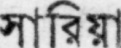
সারিয়া
